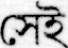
সেই
